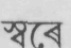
স্বৰে
